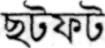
ছটফট
